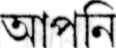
আপনি
